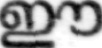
ഈ
